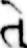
તે
